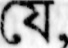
যে,
